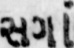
સગાં
